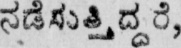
ನಡೆಸುತ್ತಿದ್ದರೆ,
